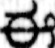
ಈ
